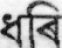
ধৰি
